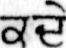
ਕਦੇ
